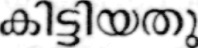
കിട്ടിയതു
